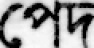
পেদ
